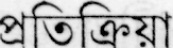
প্রতিক্রিয়া
